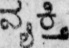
ವ್ಯಕ್ತಿ
